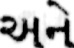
અને
